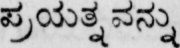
ಪ್ರಯತ್ನವನ್ನು
